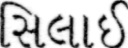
સિલાઈ
